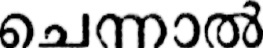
ചെന്നാല്‍
